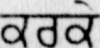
ਕਰਕੇ
